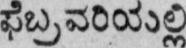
ಫೆಬ್ರವರಿಯಲ್ಲಿ
